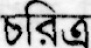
চরিত্র
